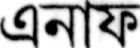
এনাফ
